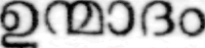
ഉന്മാദം
